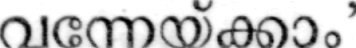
വന്നേയ്ക്കാം'
